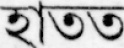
হাতত
